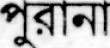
পুরানা
